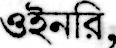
ওইনরি,
